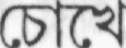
চোখে
